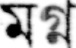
মগ্ন
